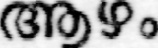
ആഴം
